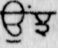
ਉਂਝ
